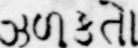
ઝળકતો
